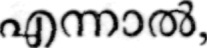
എന്നാല്‍,
